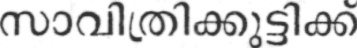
സാവിത്രിക്കുട്ടിക്ക്
